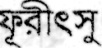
ফূরীৎসু
